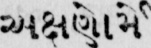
અક્ષણોર્મે
